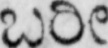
ಬರೀ
